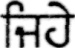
ਜਿਹੇ
